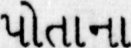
પોતાના
